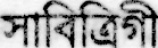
সাবিত্রিগী
